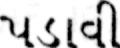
પડાવી
